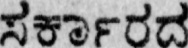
ಸರ್ಕಾರದ
